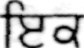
ਇਕ
